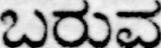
ಬರುವ
